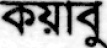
কয়াবু
